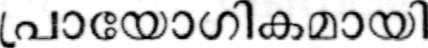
പ്രായോഗികമായി
